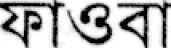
ফাওবা
